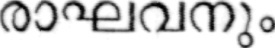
രാഘവനും
